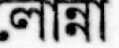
লোন্না
